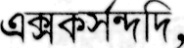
এক্সকর্সন্দদি,
